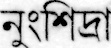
নুংশিদ্রা
